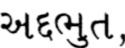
અદભુત,
